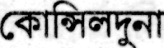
কোন্সিলদুনা
